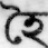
হৈ
